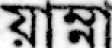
য়াম্না
